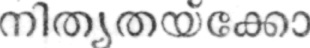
നിത്യതയ്ക്കോ
